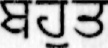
ਬਹੁਤ
